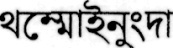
থম্মোইনুংদা
